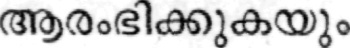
ആരംഭിക്കുകയും
